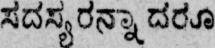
ಸದಸ್ಯರನ್ನಾದರೂ
